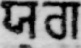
ਯੁਗ
